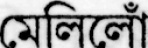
মেলিলোঁ
